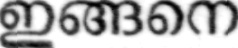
ഇങ്ങനെ
